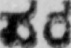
ಪರ
